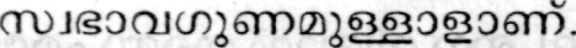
സ്വഭാവഗുണമുള്ളാളാണ്.
